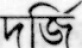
দর্জি
